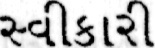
સ્વીકારી
